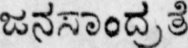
ಜನಸಾಂದ್ರತೆ
